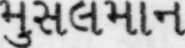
મુસલમાન
